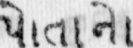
પોતાનો
